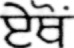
ਏਥੋਂ
